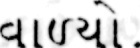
વાળ્યો.
